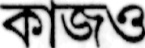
কাজও
